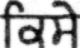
ਕਿਸੇ
